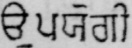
ਉਪਯੋਗੀ
